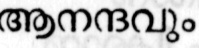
ആനന്ദവും
